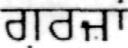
ਗ਼ਰਜ਼ਾਂ
